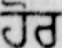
ਹੋਰ
